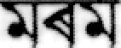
মৰম
